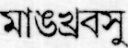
মাঙখ্রবসু
